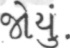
જોયું.
